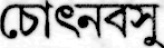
চোৎনবসু
